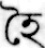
হৈ
